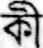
কী
